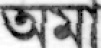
অমা
